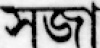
সজা
